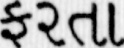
ફરતા
